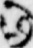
છે
